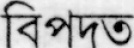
বিপদত
